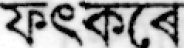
ফৎকৰে
